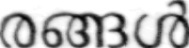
രങ്ങള്‍
